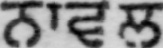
ਨਾਵਲ
